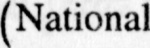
(National
